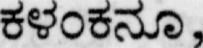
ಕಳಂಕನೂ,
